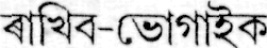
ৰাখিব-ভোগাইক
